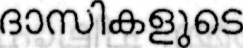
ദാസികളുടെ
